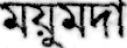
ময়ুমদা
